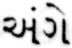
અંગે
